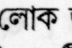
লোক
